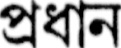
প্রধান
